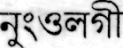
নুংওলগী
